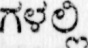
ಗಳಲ್ಲಿ
